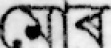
মোৰ
